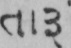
તારૂં
